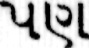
પણ
